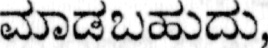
ಮಾಡಬಹುದು,
